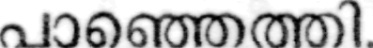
പാഞ്ഞെത്തി.
